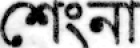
শেংনা
